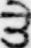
ਤੇ
